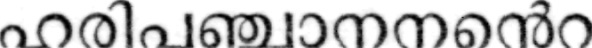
ഹരിപഞ്ചാനനന്റെ
